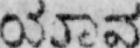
ಯಾವ
